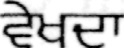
ਵੇਖਦਾ
